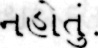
નહોતું.
